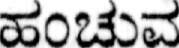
ಹಂಚುವ
